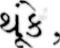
થૂંકે,
